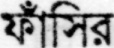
ফাঁসির
